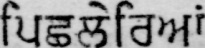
ਪਿਛਲੇਰਿਆਂ
